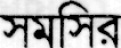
সমসির
